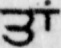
ਤਾਂ
